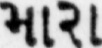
મારા
